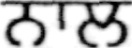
ਨਾਲ
